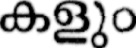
കളും
